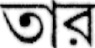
তার
